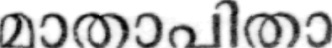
മാതാപിതാ
